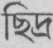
ছিদ্ৰ
